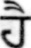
ਹੈ
